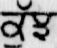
ਕੁੱਝ
